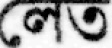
লেত
